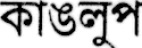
কাঙলুপক
